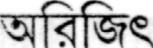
অরিজিৎ
